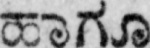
ಹಾಗೂ
